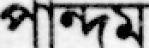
পান্দম
